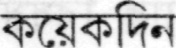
কয়েকদিন
